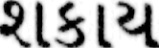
શકાય
